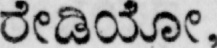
ರೇಡಿಯೋ,
